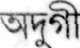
অদুগী
